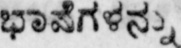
ಭಾಷೆಗಳನ್ನು
